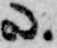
ಎ.
